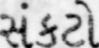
સંકટો
